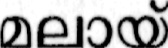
മലായ്
